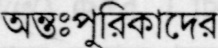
অন্তঃপুরিকাদের
